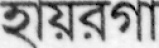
হায়রগা
